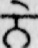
ਨੇ
